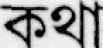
কথা
